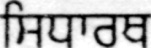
ਸਿਧਾਰਥ
